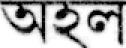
অহল
